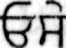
ਓਸੇ
